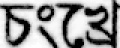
চংখ্রে
